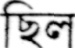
ছিল
